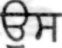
ਉਸ
